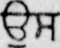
ਉਸ
